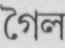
গৈল
